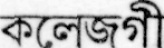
কলেজগী
